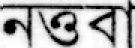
নত্তবা
